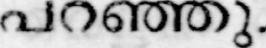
പറഞ്ഞു.
